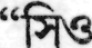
"সিও
